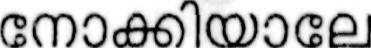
നോക്കിയാലേ
